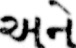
અને
